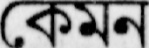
কেমন
